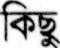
কিছু
